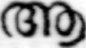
ആ
